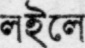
লইলে
